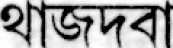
থাজদবা
